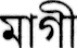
মাগী
